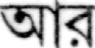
আর
